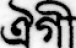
ঐগী
